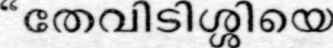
"തേവിടിശ്ശിയെ
